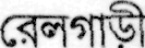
রেলগাড়ী
